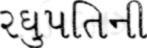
રઘુપતિની
